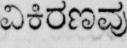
ವಿಕಿರಣವು
